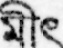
মীৎ
